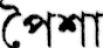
পৈশা
